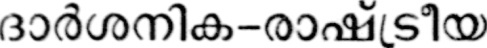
ദാര്‍ശനിക-രാഷ്ട്രീയ
